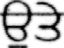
ਉਤੇ
